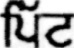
ਪਿੱਟ
